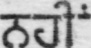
ਨਹੀਂ
